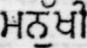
ਮਨੁੱਖੀ
